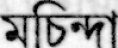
মচিন্দা
